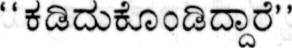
"ಕಡಿದುಕೊಂಡಿದ್ದಾರೆ”
